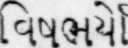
વિષભર્યો
